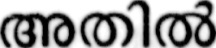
അതില്‍
